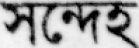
সন্দেহ
